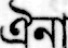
ঐনা
